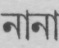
নানা
